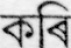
কৰি
